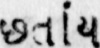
છતાંય
